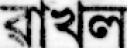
ৱাখল
